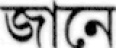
জানে
